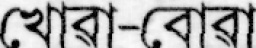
খোৱা-বোৱা
